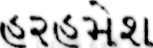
હરહમેશ
